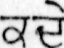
ਕਦੇ
